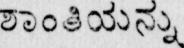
ಶಾಂತಿಯನ್ನು
